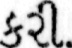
કરી.
